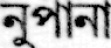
নুপানা
